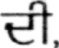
ਦੀ,
